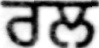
ਰਲ
